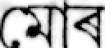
মোৰ
